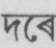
দৰে
